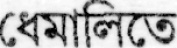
ধেমালিতে
